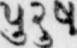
પુરુષ
